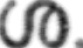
ശ.
